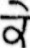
ਕੇ
